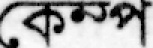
কেম্প
